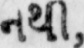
નથી,
